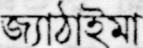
জ্যাঠাইমা
